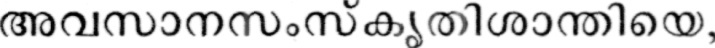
അവസാനസംസ്കൃതിശാന്തിയെ,
